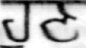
ਹੁਣ
